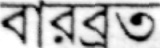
বারব্রত
